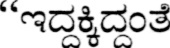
"ಇದ್ದಕ್ಕಿದ್ದಂತೆ
